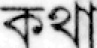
কথা
